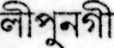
লীপুনগী
